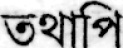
তথাপি
